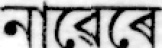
নাৱেৰে
